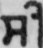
ਸੀ
